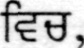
ਵਿਚ,
